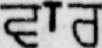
ਵਾਰ
